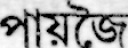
পায়জৈ
